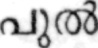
പുല്‍
